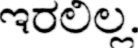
ಇರಲಿಲ್ಲ.
